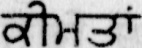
ਕੀਮਤਾਂ
